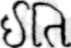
ઈતિ
